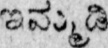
ಇಮಡಿ
